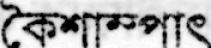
কৈশাম্পাৎ
